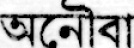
অনৌবা
